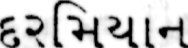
દરમિયાન
